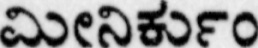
ಮೀನಿರ್ಕುಂ
